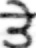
ਤੇ
